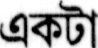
একটা
